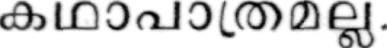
കഥാപാത്രമല്ല.
